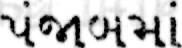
પંજાબમાં
